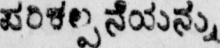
ಪರಿಕಲ್ಪನೆಯನ್ನು
